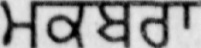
ਮਕਬਰਾ
